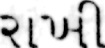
રાખી
